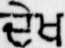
ਦੇਖ
